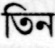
তিন
